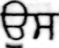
ਉਸ
